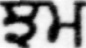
ਝਮ
